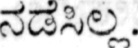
ನಡೆಸಿಲ್ಲ.
